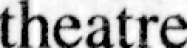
theatre
